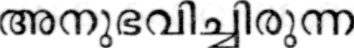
അനുഭവിച്ചിരുന്ന
